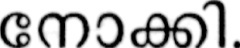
നോക്കി.
